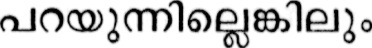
പറയുന്നില്ലെങ്കിലും
